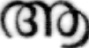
ആ
